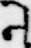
ને
